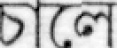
চালে
